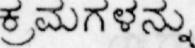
ಕ್ರಮಗಳನ್ನು
